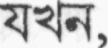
যখন,
